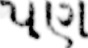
પણ
